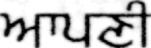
ਆਪਣੀ
